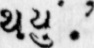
થયું.'
